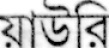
য়াওরি
